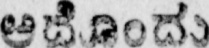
ಅದೊಂದು
